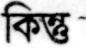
কিন্তু
